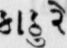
કાઠુરે
